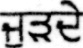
ਜੁੜਦੇ
